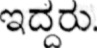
ಇದ್ದರು.
